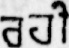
ਰਹੀ
